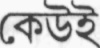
কেউই
